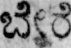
ಬೇರೆ
